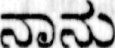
ನಾನು
